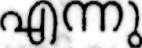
എന്നു
